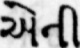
એની
